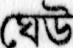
ঘেউ
